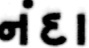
નંદા
